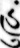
હું
